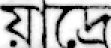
য়াদ্রে
